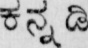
ಕನ್ನಡಿ
